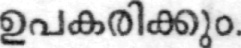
ഉപകരിക്കും.
